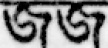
জজ
